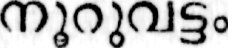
നൂറുവട്ടം
